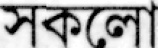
সকলো
